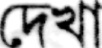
দেখা
